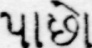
પાછો
